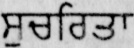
ਸੁਚਰਿਤਾ
